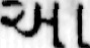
આ
